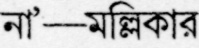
না’–মল্লিকার
